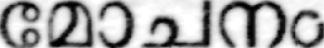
മോചനം
